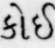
કોઈ
